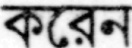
করেন
